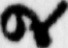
જ
